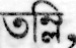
তম্লি,
